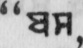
''ਬਸ,
